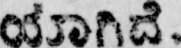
ಯಾಗಿದೆ.
